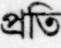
প্রতি
